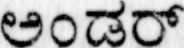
ಅಂಡರ್
